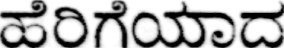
ಹೆರಿಗೆಯಾದ
